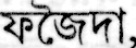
ফজৈদা,
